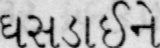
ઘસડાઈને
